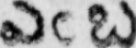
ಎಂಬ
